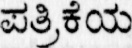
ಪತ್ರಿಕೆಯ
